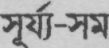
সূৰ্য্য-সম
